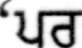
'ਪਰ
